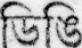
ডিঙি
